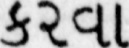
કરવા
